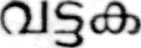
വട്ടക
